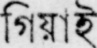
গিয়াই
